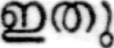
ഇതു
